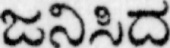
ಜನಿಸಿದ
